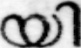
യി
